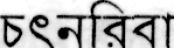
চৎনরিবা
